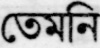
তেমনি
